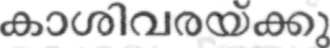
കാശിവരയ്ക്കു
